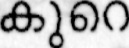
കുറെ
